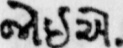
જોઈએ.
